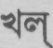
খল্
